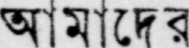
আমাদের
